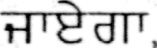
ਜਾਏਗਾ,
